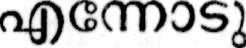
എന്നോടു
